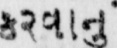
કરવાનું
